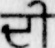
ਦੀ
